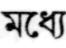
মধ্যে
